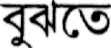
বুঝতে
